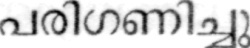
പരിഗണിച്ചു
